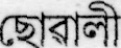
ছোৱালী
